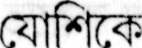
যোশিকে
